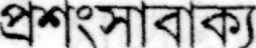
প্রশংসাবাক্য
